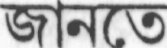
জানতে
